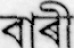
বাৰী
